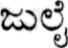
ಜುಲೈ
